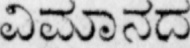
ವಿಮಾನದ
